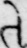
તે
